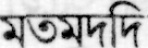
মতমদদি
